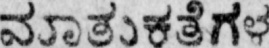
ಮಾತುಕತೆಗಳ
